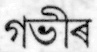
গভীৰ
